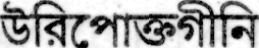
উরিপোক্তগীনি
